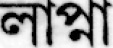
লাপ্না
